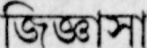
জিজ্ঞাসা
